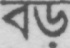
বড়
